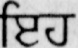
ਇਹ
